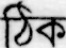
ঠিক
